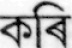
কৰি
